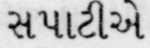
સપાટીએ
